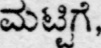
ಮಟ್ಟಿಗೆ,
